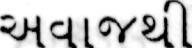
અવાજથી
